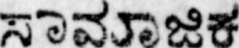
ಸಾಮಾಜಿಕ
